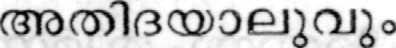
അതിദയാലുവും
